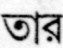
তার
